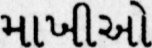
માખીઓ
